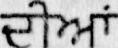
ਦੀਆਂ
